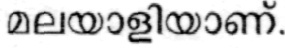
മലയാളിയാണ്.
